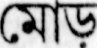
মোড়
